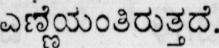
ಎಣ್ಣೆಯಂತಿರುತ್ತದೆ.
